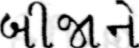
બીજાને
